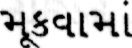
મૂકવામાં
